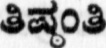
ತಿಷ್ಠಂತಿ
